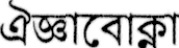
ঐজ্ঞাবোক্না
